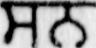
ਸਨ
